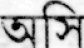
অসি
